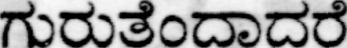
ಗುರುತೆಂದಾದರೆ
